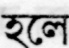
হলে
